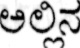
ಅಲ್ಲಿನ
